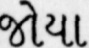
જોયા
